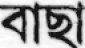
বাছা
